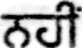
ਨਹੀਂ
